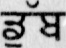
ਡੁੱਬ
